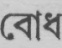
বোধ
